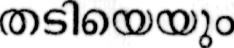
തടിയെയും
